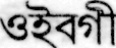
ওইবগী
